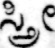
ಸ್ತ್ರೀ
